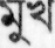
মুখ
